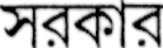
সরকার
